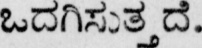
ಒದಗಿಸುತ್ತದೆ.
